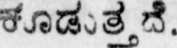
ಕೂಡುತ್ತದೆ.
